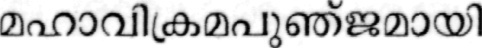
മഹാവിക്രമപുഞ്ജമായി
